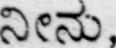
ನೀನು,
